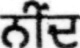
ਨੀਂਦ
